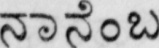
ನಾನೆಂಬ
